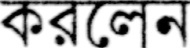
করলেন
